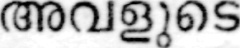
അവളുടെ
